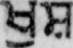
ਖੁਸ਼
